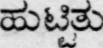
ಹುಟ್ಟಿತು
